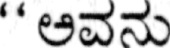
"ಅವನು
